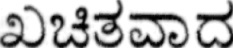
ಖಚಿತವಾದ
